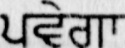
ਪਵੇਗਾ
